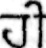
ਹੀ
